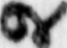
જ
